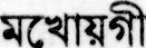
মখোয়ঘী
